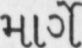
માર્ગે
